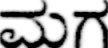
ಮಗ
